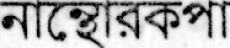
নান্থোরকপা
